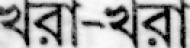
খরা-খরা
